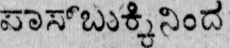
ಪಾಸ್‌ಬುಕ್ಕಿನಿಂದ
